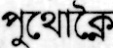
পুথোক্নৈ
